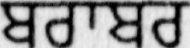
ਬਰਾਬਰ
